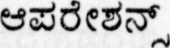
ಆಪರೇಶನ್ಸ್
